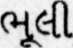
ભૂલી
